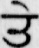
ਤੇ
